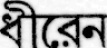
ধীরেন
